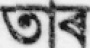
তাৰ
